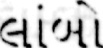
લાંબો
